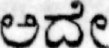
ಅದೇ
